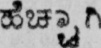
ಹೆಚ್ಚಾಗಿ
